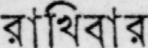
রাখিবার
